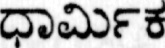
ಧಾರ್ಮಿಕ
